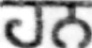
ਹਨ
